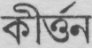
কীৰ্ত্তন
